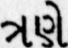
ત્રણે
